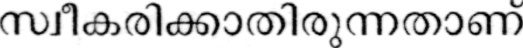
സ്വീകരിക്കാതിരുന്നതാണ്
